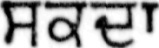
ਸਕਦਾ
